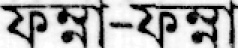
ফম্না-ফম্না
